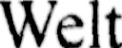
Welt
